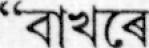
"বাখৰে
